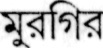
মুরগির
